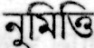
নুমিত্তি
